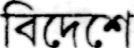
বিদেশে
